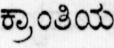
ಕ್ರಾಂತಿಯ
